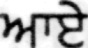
ਆਏ
